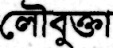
লৌবুক্তা
